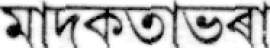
মাদকতাভৰা
